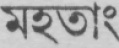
মহতাং
